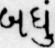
બધું
